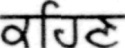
ਕਹਿਣ
